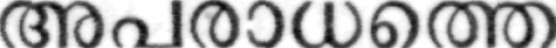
അപരാധത്തെ
